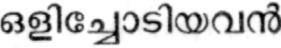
ഒളിച്ചോടിയവന്‍
